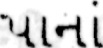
પાનાં
